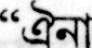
“ঐনা
